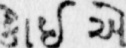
કોઈએ
